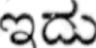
ಇದು
